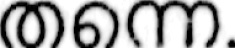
തന്നെ.
